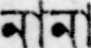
নানা
